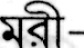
মরী-
